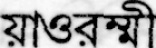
য়াওরম্মী
